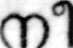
നീ
